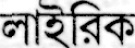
লাইরিক
